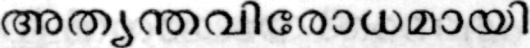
അത്യന്തവിരോധമായി
